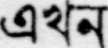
এখন
